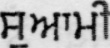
ਸੁਆਮੀ
